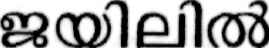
ജയിലില്‍
